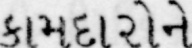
કામદારોને
